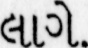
લાગે.
